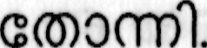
തോന്നി.
